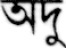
অদু
